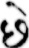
છે
